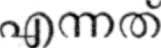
എന്നത്
